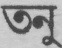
তনু
